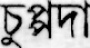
চুপ্পদা
